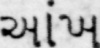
આંખ
